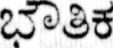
ಭೌತಿಕ
